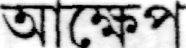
আক্ষেপ
